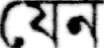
যেন
